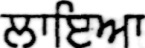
ਲਾਇਆ
